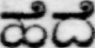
ಹೆದೆ
